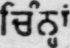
ਚਿੰਨ੍ਹਾਂ
